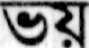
ভয়
